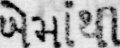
બેમાંથી
